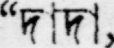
‘‘দাদা,
